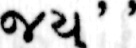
જય"
